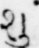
શું
